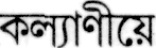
কল্যাণীয়ে
